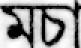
মচা
